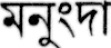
মনুংদা
